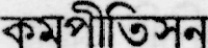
কমপীতিসন
